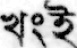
খংই
